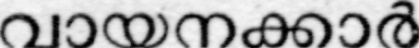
വായനക്കാര്‍
